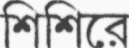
শিশিরে
